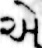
એ
